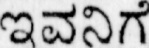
ಇವನಿಗೆ
